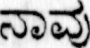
ನಾವು
